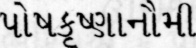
પોષકૃષ્ણાનૌમી
